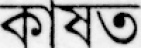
কাষত
